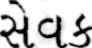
સેવક
